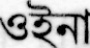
ওইনা
